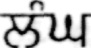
ਲੰਘ
